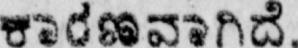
ಕಾರಣವಾಗಿದೆ.
